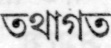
তথাগত
